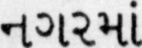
નગરમાં
